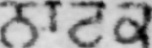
ਨਾਟਕ
